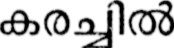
കരച്ചില്‍
